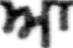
ਆ
